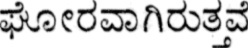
ಘೋರವಾಗಿರುತ್ತವೆ
